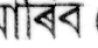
মাৰিব
